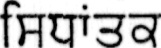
ਸਿਧਾਂਤਕ
